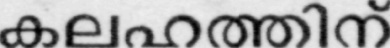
കലഹത്തിന്
